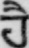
ਹੈ
